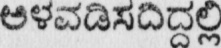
ಅಳವಡಿಸದಿದ್ದಲ್ಲಿ
